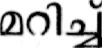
മറിച്ച്
